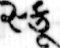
સ્ક્રૂ
